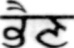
ਭੈਣ
